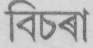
বিচৰা
